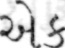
એક
